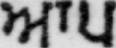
ਆਪ
